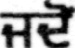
ਜਦੋਂ
